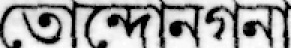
তোন্দোনগনা
